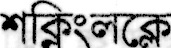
শক্নিংলক্লে
